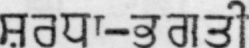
ਸ਼ਰਧਾ-ਭਗਤੀ
